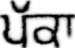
ਪੱਕਾ
